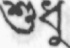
শুধু
